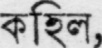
কহিল,
